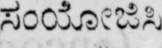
ಸಂಯೋಜಿಸಿ
